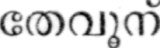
തേവൂന്
